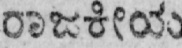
ರಾಜಕೀಯ
